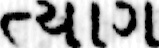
ત્યાગ
